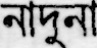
নাদুনা
